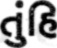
તુંહિ
